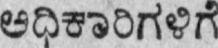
ಅಧಿಕಾರಿಗಳಿಗೆ
